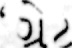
'ગ્રેટ
